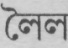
লৈল
